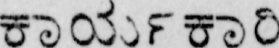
ಕಾರ್ಯಕಾರಿ
